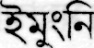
ইমুংনি
